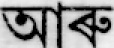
আৰু
